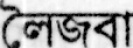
লৈজবা
